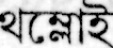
থম্লোই
